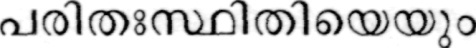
പരിതഃസ്ഥിതിയെയും
